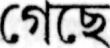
গেছে
